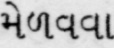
મેળવવા
